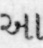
આ
